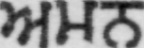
ਅਮਨ
